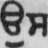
ਉਸ
